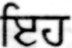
ਇਹ
